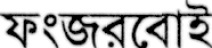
ফংজরবোই
